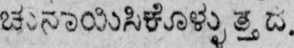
ಚುನಾಯಿಸಿಕೊಳ್ಳುತ್ತದೆ.
